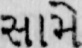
સામે
